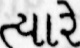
ત્યારે
